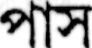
পাস
